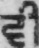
ਵੀ
